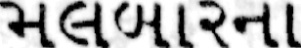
મલબારના
